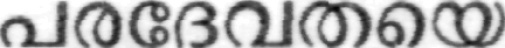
പരദേവതയെ
